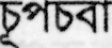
চূপচবা
